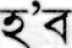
হ'ব
